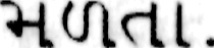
મળતા.
